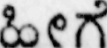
ಹೀಗೆ
